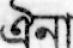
ঐনা
